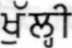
ਖੁੱਲ੍ਹੀ
